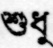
শুধু
